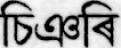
চিঞৰি
